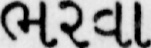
ભરવા
